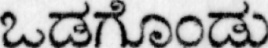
ಒಡಗೊಂಡು
